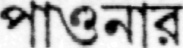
পাওনার
